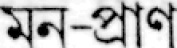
মন-প্রাণ
